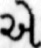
એ
